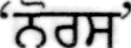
'ਨੋਰਸ'
